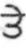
ਤੇ
